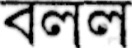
বলল
